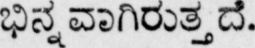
ಭಿನ್ನವಾಗಿರುತ್ತದೆ.
